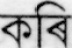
কৰি
